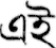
এই
